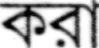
করা
